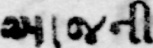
આજની
